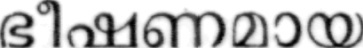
ഭീഷണമായ
